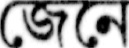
জেনে
